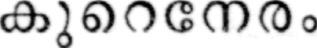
കുറെനേരം
